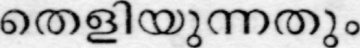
തെളിയുന്നതും
